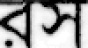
রস
